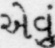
એવું
